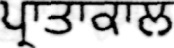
ਪ੍ਰਾਤਾਕਾਲ
